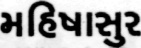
મહિષાસુર
